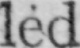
led
